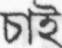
চাই
